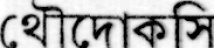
থৌদোকসি
